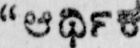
“ಆರ್ಥಿಕ
